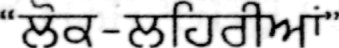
''ਲੋਕ-ਲਹਿਰੀਆਂ'
